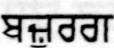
ਬਜ਼ੁਰਗ
